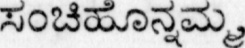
ಸಂಚಿಹೊನ್ನಮ್ಮ,
